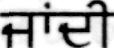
ਜਾਂਦੀ
